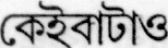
কেইবাটাও
